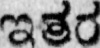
ಇತರ
